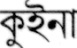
কুইনা
